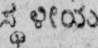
ಸ್ಥಳೀಯ
